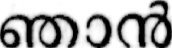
ഞാന്‍
